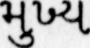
મુખ્ય
